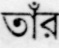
তাঁর
